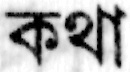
কথা
